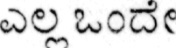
ಎಲ್ಲಒಂದೇ
